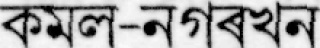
কমল-নগৰখন
